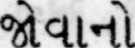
જોવાનો
